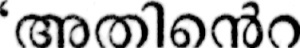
'അതിൻറെ
